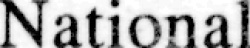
National
